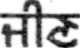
ਜੀਣ
